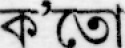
ক'তো
